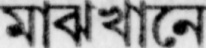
মাঝখানে
